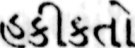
હકીકતો
